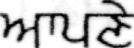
ਆਪਣੇ
